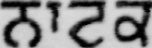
ਨਾਟਕ
